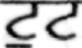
ਟੁਟ
